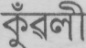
কুঁৱলী
